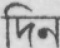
দিন
